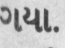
ગયા.
